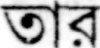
তার
